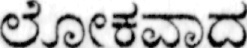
ಲೋಕವಾದ
